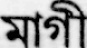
মাগী
